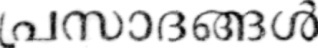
പ്രസാദങ്ങള്‍
